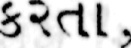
કરતા,
